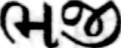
ભજી
